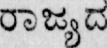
ರಾಜ್ಯದ
